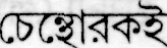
চেন্থোরকই
